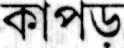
কাপড়
